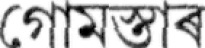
গোমস্তাৰ
